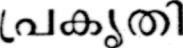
പ്രകൃതി
